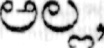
ಅಲ್ಲ,
